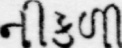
નીકળી
